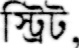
স্ট্রিট,
